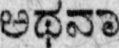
ಅಥವಾ
